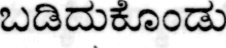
ಬಡಿದುಕೊಂಡು
